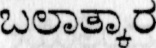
ಬಲಾತ್ಕಾರ
